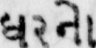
ઘરનો
